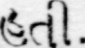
હતી.
